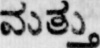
ಮತ್ತು
